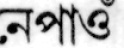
নেপাওঁ
